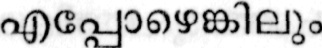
എപ്പോഴെങ്കിലും
